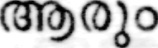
ആരും
